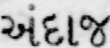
અંદાજ
